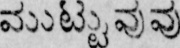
ಮುಟ್ಟುವುವು
